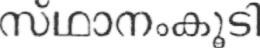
സ്ഥാനംകൂടി
